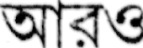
আরও
